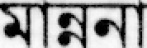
মান্ননা
